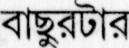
বাছুরটার
